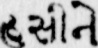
હસીને
